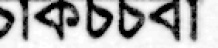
চাকচচবা
